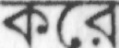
করে
